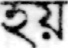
হয়
